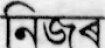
নিজৰ
